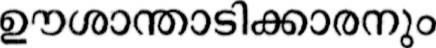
ഊശാന്താടിക്കാരനും
